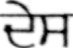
ਦੇਸ
